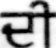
ਦੀ
